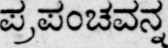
ಪ್ರಪಂಚವನ್ನ
